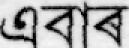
এবাৰ
